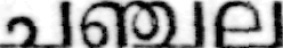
ചഞ്ചല
